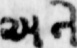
અને
